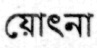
য়োৎনা
